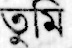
তুমি
